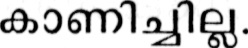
കാണിച്ചില്ല.
